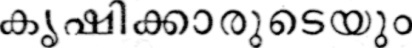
കൃഷിക്കാരുടെയും
